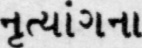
નૃત્યાંગના
